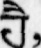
ਹੈ,
